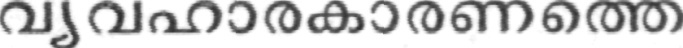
വ്യവഹാരകാരണത്തെ
